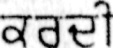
ਕਰਦੀ
